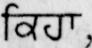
ਕਿਹਾ,
